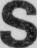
S
